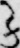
કે
